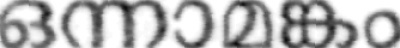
ഒന്നാമങ്കം
